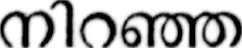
നിറഞ്ഞ
